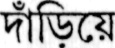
দাঁড়িয়ে
